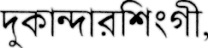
দুকান্দারশিংগী,
